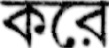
করে
